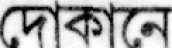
দোকানে
